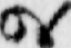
જ
